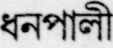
ধনপালী
